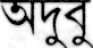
অদুবু
